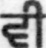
ਵੀ
